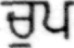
ਚੁਪ
